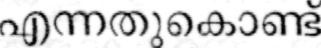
എന്നതുകൊണ്ട്
